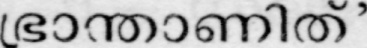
ഭ്രാന്താണിത്'’
